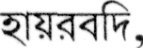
হায়রবদি,
